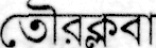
তৌরক্লবা
